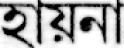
হায়না
